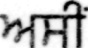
ਅਸੀਂ
